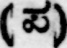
(ಪ)
